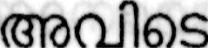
അവിടെ
